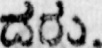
ದರು.
